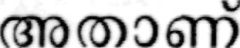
അതാണ്
